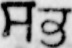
ਸਭ
